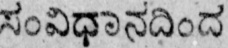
ಸಂವಿಧಾನದಿಂದ
